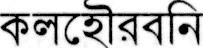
কলহৌরবনি
